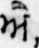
ਐ,
